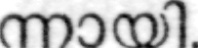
ന്നായി.
